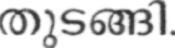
തുടങ്ങി.
